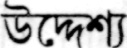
উদ্দেশ্য
